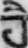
ਹੈ
